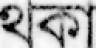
থকা
